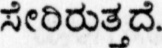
ಸೇರಿರುತ್ತದೆ.
